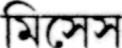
মিসেস
